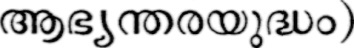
ആഭ്യന്തരയുദ്ധം)
